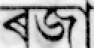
ৰজা
